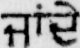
ਜਾਂਦੇ
